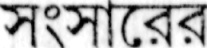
সংসারের
